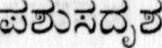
ಪಶುಸದೃಶ
